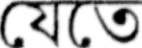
যেতে
